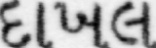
દાખલ
